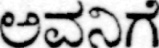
ಅವನಿಗೆ
